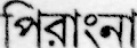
পিরাংনা
